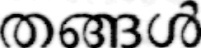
തങ്ങള്‍
